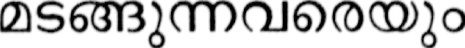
മടങ്ങുന്നവരെയും
